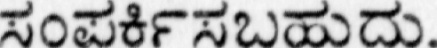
ಸಂಪರ್ಕಿಸಬಹುದು.
